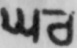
ਘਰ
